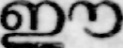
ഈ
